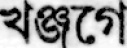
খঞ্জগে
